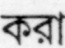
করা
